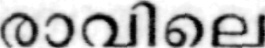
രാവിലെ
